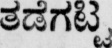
ತಡೆಗಟ್ಟಿ
